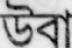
উবা
